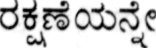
ರಕ್ಷಣೆಯನ್ನೇ
